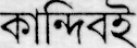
কান্দিবই
